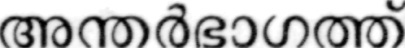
അന്തര്‍ഭാഗത്ത്
